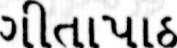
ગીતાપાઠ
